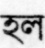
হল
